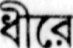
ধীরে
